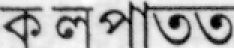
কলপাতত
